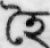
হৈ
